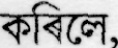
কৰিলে,
